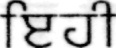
ਇਹੀ
